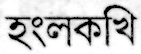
হংলকখি
